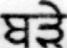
ਬੜੇ
